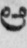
ಆ
